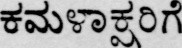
ಕಮಳಾಕ್ಷರಿಗೆ
